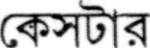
কেসটার
